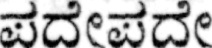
ಪದೇಪದೇ
